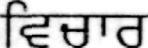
ਵਿਚਾਰ
